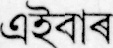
এইবাৰ
